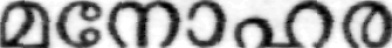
മനോഹര
